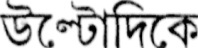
উল্টোদিকে
